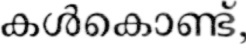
കള്‍ക്കൊണ്ട്,
